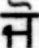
ਜੋ
